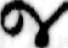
જ
